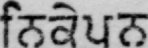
ਨਿਕੇਪਨ
